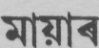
মায়াৰ
